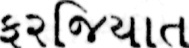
ફરજિયાત
